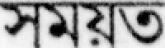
সময়ত
